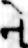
ને
